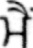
ਮੈਂ
